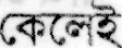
কেলেই
